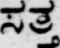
ಸತ್ತ
